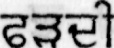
ਫੜਦੀ
